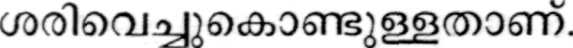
ശരിവെച്ചുകൊണ്ടുള്ളതാണ്.
